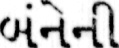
બંનેની
